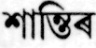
শান্তিৰ
